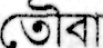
তৌবা
